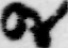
જ
